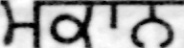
ਮਕਾਨ
